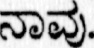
ನಾವು.
